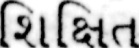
શિક્ષિત
